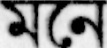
মনে
